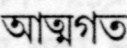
আত্মগত
